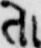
તો
